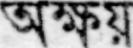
অক্ষয়
